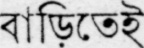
বাড়িতেই
